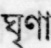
ঘৃণা
